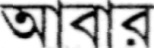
আবার
